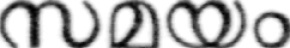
സമയം
